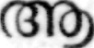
ആ
